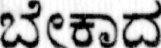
ಬೇಕಾದ
